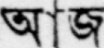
আজ
